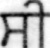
ਸੀ
